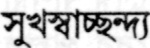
সুখস্বাচ্ছন্দ্য
